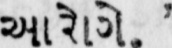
આરોગે.'
